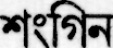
শংগিন
